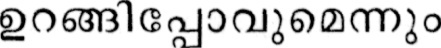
ഉറങ്ങിപ്പോവുമെന്നും
